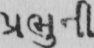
પ્રભુની
